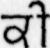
ਕੀ
